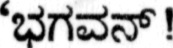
‘ಭಗವನ್!
